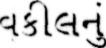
વકીલનું
